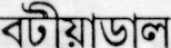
বটীয়াডাল
